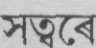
সত্বৰে
